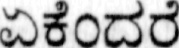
ಏಕೆಂದರೆ
